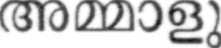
അമ്മാളു
